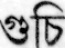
গুচি
